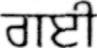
ਗਈ
